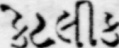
કેટલીક
